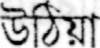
উঠিয়া
